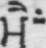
ਮੈਂ
